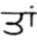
ਤਾਂ
